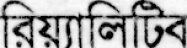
রিয়্যালিটিব
